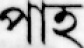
পাহ
